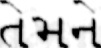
તેમને
